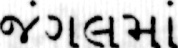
જંગલમાં
